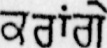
ਕਰਾਂਗੇ
